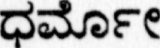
ಧರ್ಮೋ
